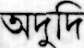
অদুদি
